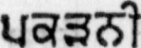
ਪਕੜਨੀ
